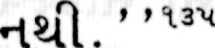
નથી."૧૩૫
